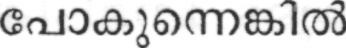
പോകുന്നെങ്കില്‍
